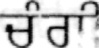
ਚੰਗੀ
